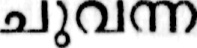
ചുവന്ന
